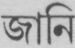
জানি
